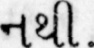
નથી.
